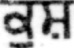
ਕੁਸ਼
